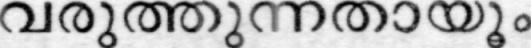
വരുത്തുന്നതായും
